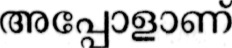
അപ്പോളാണ്
